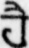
ਹੈ
